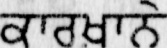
ਕਾਰਖ਼ਾਨੇ
